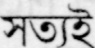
সত্যই
